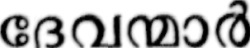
ദേവന്മാര്‍
